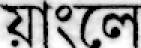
য়াংলে
